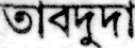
তাবদুদা
